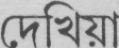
দেখিয়া
